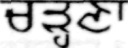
ਚੜ੍ਹਣਾ
